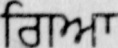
ਗਿਆ
